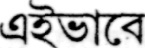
এইভাবে
